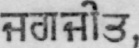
ਜਗਜੀਤ,
